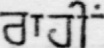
ਰਾਹੀਂ
